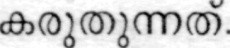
കരുതുന്നത്.
